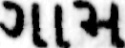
ગામ
